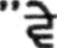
''ਵੇ
